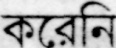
করেনি
